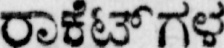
ರಾಕೆಟ್‌ಗಳ
